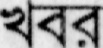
খবর
